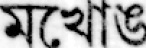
মখোঙ
